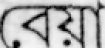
বেয়া
